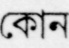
কোন
